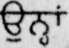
ਉਨ੍ਹਾਂ
